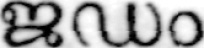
ജഡം
